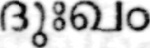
ദുഃഖം
